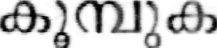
കൂമ്പുക
